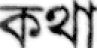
কথা
